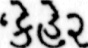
'કેહેર
